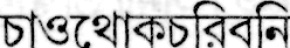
চাওথোকচরিবনি
